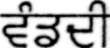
ਵੰਡਦੀ
